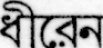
ধীরেন
